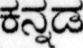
ಕನ್ನಡ
